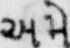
અમે
